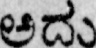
ಅದು
